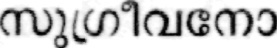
സുഗ്രീവനോ
